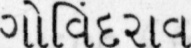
ગોવિંદરાવ
